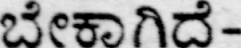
ಬೇಕಾಗಿದೆ-
